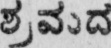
ಶ್ರಮದ
